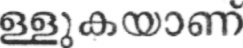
ള്ളുകയാണ്
